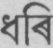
ধৰি
